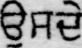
ਉਸਦੇ
